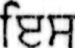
ਇਸ
